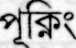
পূক্নিং
